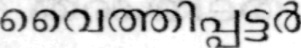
വൈത്തിപ്പട്ടര്‍
